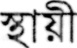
স্থায়ী
